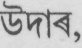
উদাৰ,
